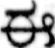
ಈ
